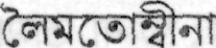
লৈমতোম্বীনা
